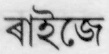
ৰাইজে
